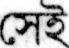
সেই
